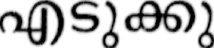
എടുക്കു
